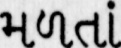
મળતાં
